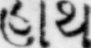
હાથ
